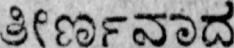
ತೀರ್ಣವಾದ
